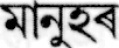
মানুহৰ
